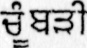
ਚੂੰਬੜੀ
